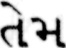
તેમ
